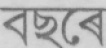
বছৰে
